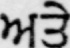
ਅਤੇ
